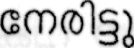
നേരിട്ടു
